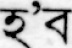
হ'ব
